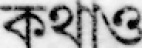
কথাও
